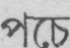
পচে
